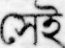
সেই
